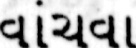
વાંચવા
